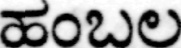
ಹಂಬಲ
